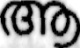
ആ
